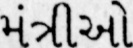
મંત્રીઓ
